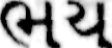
ભય
